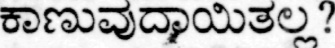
ಕಾಣುವುದಾಯಿತಲ್ಲ?
